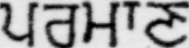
ਪਰਮਾਣ
